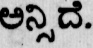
ಅನ್ಸಿದೆ.
